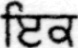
ਇਕ
